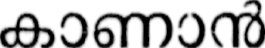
കാണാന്‍
